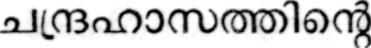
ചന്ദ്രഹാസത്തിന്റെ
